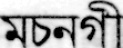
মচনগী
